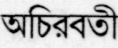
অচিরবতী
